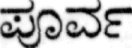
ಪೂರ್ವ
